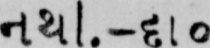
નથી.-દા.
